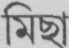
মিছা
